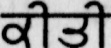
ਕੀਤੀ
